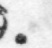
છે.
